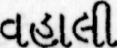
વહાલી
